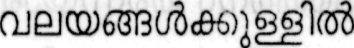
വലയങ്ങള്‍ക്കുള്ളില്‍
